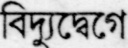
বিদ্যুদ্বেগে
